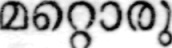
മറ്റൊരു
